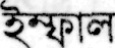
ইম্ফাল
